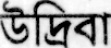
উদ্রিবা
